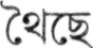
থৈছে
